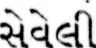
સેવેલી
